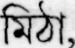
মিঠা,
